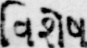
ફરિયાદો
